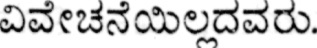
ವಿವೇಚನೆಯಿಲ್ಲದವರು.
